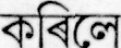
কৰিলে
